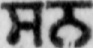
ਸਨ
